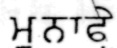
ਮੁਨਾਫ਼ੇ
